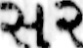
સર
